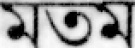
মতম
